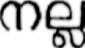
നല്ല
